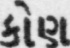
કોણ
